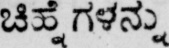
ಚಿಹ್ನೆಗಳನ್ನು
